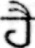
ਹੈ
